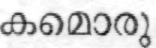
കമൊരു
